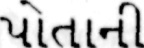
પોતાની
